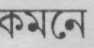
কমনে
